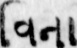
વિના
